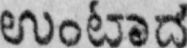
ಉಂಟಾದ
